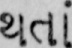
થતાં
